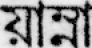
য়াম্না
